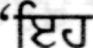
'ਇਹ
